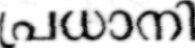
പ്രധാനി
